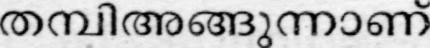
തമ്പിഅങ്ങുന്നാണ്
